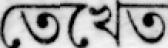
তেখেত
